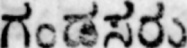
ಗಂಡಸರು
